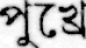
পুখ্রে
